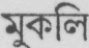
মুকলি
